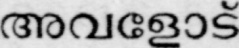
അവളോട്
